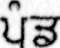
ਪੰਡ
